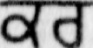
ਕਰ
